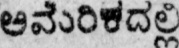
ಅಮರಿಕದಲ್ಲಿ
